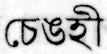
চেঙহী
